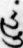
હું
